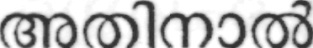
അതിനാല്‍
